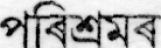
পৰিশ্রমৰ
